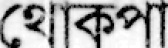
থোকপা
